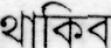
থাকিব
